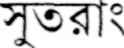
সুতরাং
